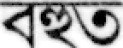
বহুত
